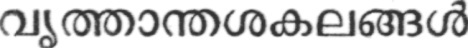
വൃത്താന്തശകലങ്ങള്‍
